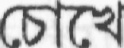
চোখে
